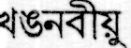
খঙনবীয়ু
